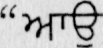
''ਆਉ
